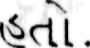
હતો.
